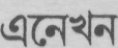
এনেখন
